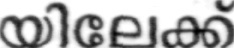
യിലേക്ക്
